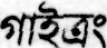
গাইত্রং
